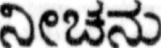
ನೀಚನು
